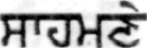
ਸਾਹਮਣੇ
